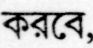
করবে,
